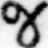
જ
